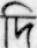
দি
